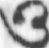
ও
